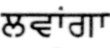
ਲਵਾਂਗਾ
